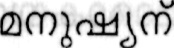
മനുഷ്യന്
